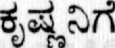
ಕೃಷ್ಣನಿಗೆ
